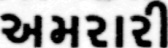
અમરારી
